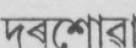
দৰশোৱা
